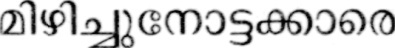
മിഴിച്ചുനോട്ടക്കാരെ
